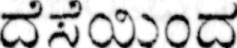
ದೆಸೆಯಿಂದ
